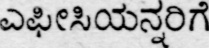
ಎಫೀಸಿಯನ್ನರಿಗೆ
